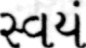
સ્વયં
